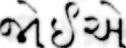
જોઇએ
